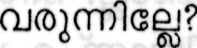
വരുന്നില്ലേ?
